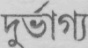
দুৰ্ভাগ্য
